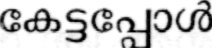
കേട്ടപ്പോള്‍
